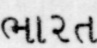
ભારત
